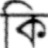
কি
